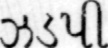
ઝડપી
